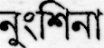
নুংশিনা
